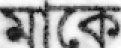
মাকে
